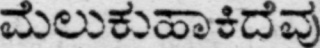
ಮೆಲುಕುಹಾಕಿದೆವು
